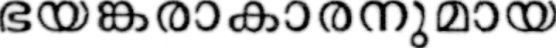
ഭയങ്കരാകാരനുമായ
